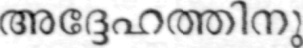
അദ്ദേഹത്തിനു
